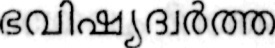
ഭവിഷ്യദ്വര്‍ത്ത
